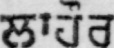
ਲਾਹੌਰ
